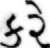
કરે
